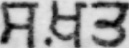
ਸਖ਼ਤ
